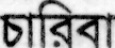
চারিবা
